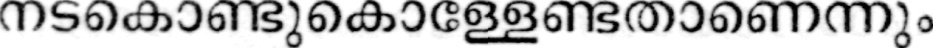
നടകൊണ്ടുകൊള്ളേണ്ടതാണെന്നും
